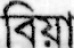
বিয়া
